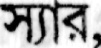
স্যার,
